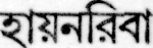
হায়নরিবা
